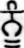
ਨੂੰ
